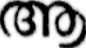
ആ
